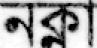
নক্না
